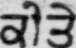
ਕੀਤੇ
